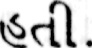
હતી.
